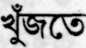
খুঁজতে
